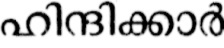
ഹിന്ദിക്കാര്‍
